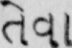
તેવા
